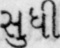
સુધી
